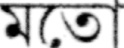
মতো
